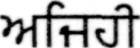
ਅਜਿਹੀ
